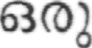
ഒരു
